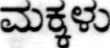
ಮಕ್ಕಳು
